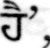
ਹੈ',
